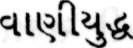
વાણીયુદ્ધ
